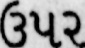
ઉપર
